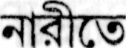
নারীতে
